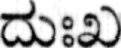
ದುಃಖ
